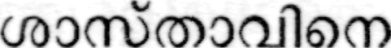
ശാസ്താവിനെ
